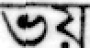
ভয়
